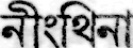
নীংথিনা
